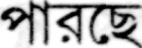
পারছে
